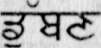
ਡੁੱਬਣ
